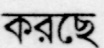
করছে
